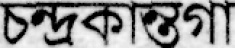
চন্দ্রকান্তগা
